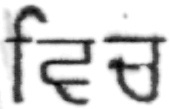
ਵਿਚ
